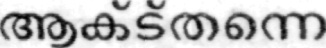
ആക്ട്തന്നെ
